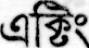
এক্টিং
